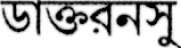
ডাক্তরনসু
